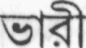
ভারী
